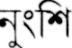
নুংশি
